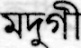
মদুগী
